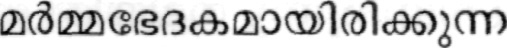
മര്‍മ്മഭേദകമായിരിക്കുന്ന
